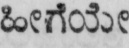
ಹೀಗೆಯೇ
